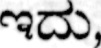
ಇದು,
